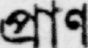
প্রাণ
